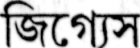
জিগ্যেস
